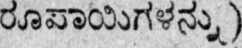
ರೂಪಾಯಿಗಳನ್ನು)
